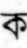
ক
